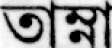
তাম্না
